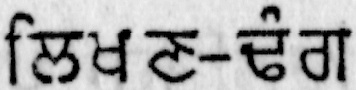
ਲਿਖਣ-ਢੰਗ
